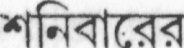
শনিবারের
